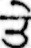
ਤੇ
